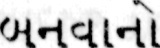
બનવાનો
